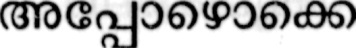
അപ്പോഴൊക്കെ
